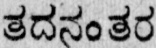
ತದನಂತರ
